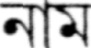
নাম
